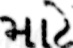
માટે
